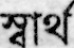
স্বার্থ
